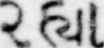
રહ્યા
